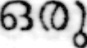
ഒരു
